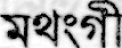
মথংগী
